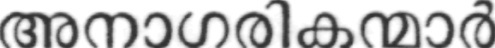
അനാഗരികന്മാര്‍
